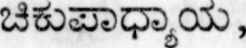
ಚಿಕುಪಾಧ್ಯಾಯ,
